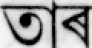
তাৰ
